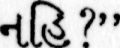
નહિ?"
